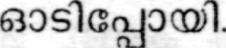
ഓടിപ്പോയി.
